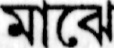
মাঝে
